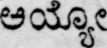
ಅಯ್ಯೋ
